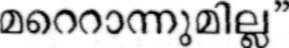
മറെറാന്നു മില്ല"
